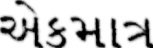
એકમાત્ર
